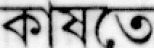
কাষতে
